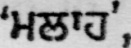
'ਮਲਾਹ',
